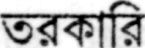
তরকারি
